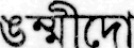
ঙম্মীদো
